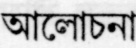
আলোচনা
